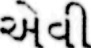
એવી
